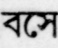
বসে
